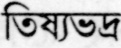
তিষ্যভদ্র
